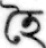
হৈ
